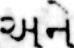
અને
